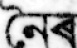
নৈৰ
